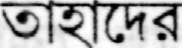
তাহাদের
